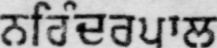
ਨਰਿੰਦਰਪਾਲ
